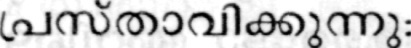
പ്രസ്താവിക്കുന്നു:
